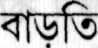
বাড়তি
